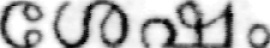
ശേഷം
